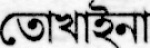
তোখাইনা
